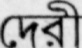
দেরী
